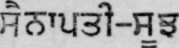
ਸੈਨਾਪਤੀ-ਸੂਝ
